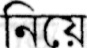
নিয়ে
